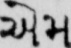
એમ
